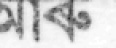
আৰু
